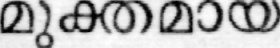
മുക്തമായ
